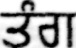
ਤੰਗ
